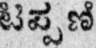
ಟಿಪ್ಪಣಿ
